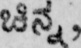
ಚಿನ್ನ,
